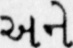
અને
